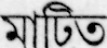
মাটিত
